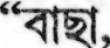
"বাছা,
